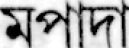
মপাদা
